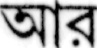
আর
